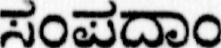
ಸ೦ಪದಾ೦
